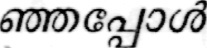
ഞ്ഞപ്പോള്‍
